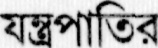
যন্ত্রপাতির
